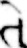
તે
